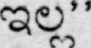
ಇಲ್ಲ"
